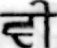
ਵੀ
